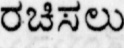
ರಚಿಸಲು
